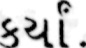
કર્યાં.
